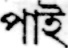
পাই
